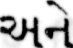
અને
